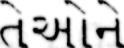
તેઓને
